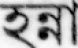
হন্না
